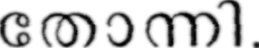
തോന്നി.
